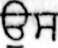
ਉਸ
